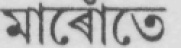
মাৰোঁতে
